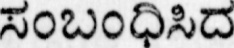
ಸಂಬಂಧಿಸಿದ
